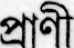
প্রাণী
